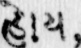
હોય,
